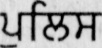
ਪੁਲਿਸ
